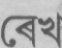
ৰেখ
